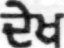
ਦੇਖ
